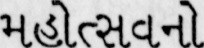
મહોત્સવનો
